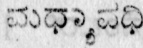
ಮಧ್ಯಾವಧಿ
